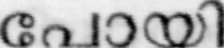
പോയി
